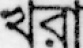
খরা
